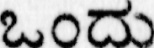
ಒಂದು
